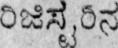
ರಿಜಿಸ್ಟರಿನ
